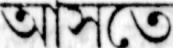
আসতে
